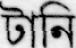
টানি
